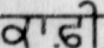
ਕਾਫ਼ੀ
